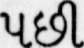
પછી
